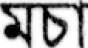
মচা
